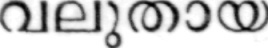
വലുതായ
